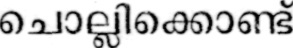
ചൊല്ലിക്കൊണ്ട്
